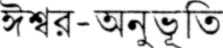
ঈশ্বর-অনুভূতি
